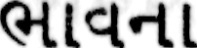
ભાવના
